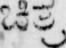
ಚಿತ್ರ
